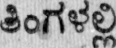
ತಿಂಗಳಲ್ಲಿ
